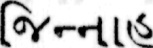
જિન્નાહ
